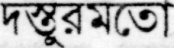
দস্তুরমতো
